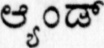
ಆಂಡ್
